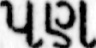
પણ
